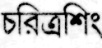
চরিত্রশিং
